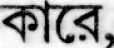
কারে,
